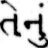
તેનું
